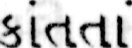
કાંતતાં
